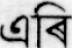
এৰি
